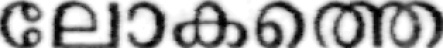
ലോകത്തെ
